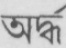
অৰ্দ্ধ
